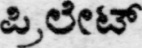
ಪ್ರಿಲೇಟ್
